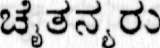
ಚೈತನ್ಯರು
